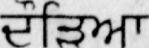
ਦੌੜਿਆ
